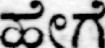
ಹೇಗೆ
